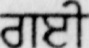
ਗਈ
